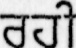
ਰਹੀ
